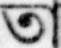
তা
